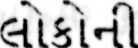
લોકોની
